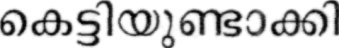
കെട്ടിയുണ്ടാക്കി
